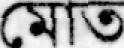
মোত
